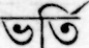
ভর্তি
